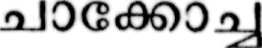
ചാക്കോച്ച
